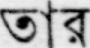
তার
